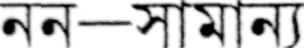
নন–সামান্য
